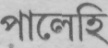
পালেহি
